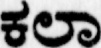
ಕಲಾ
